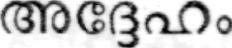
അദ്ദേഹം
